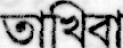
তাখিবা
